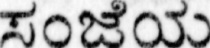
ಸಂಜೆಯ
